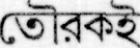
তৌরকই
